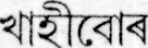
খাহীবোৰ
